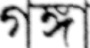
গঙ্গা
